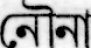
নৌনা
